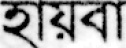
হায়বা
